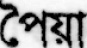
পৈয়া
